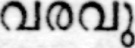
വരവു
